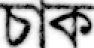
চাক
